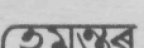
হেমন্তৰ
